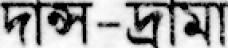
দান্স-দ্রামা
